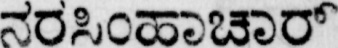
ನರಸಿಂಹಾಚಾರ್
